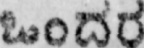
ಒಂದರ
